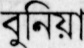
বুনিয়া
